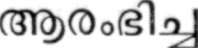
ആരംഭിച്ച
